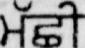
ਮੱਛੀ
